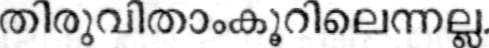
തിരുവിതാംകൂറിലെന്നല്ല.
